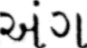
અંગ
